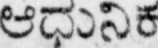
ಆಧುನಿಕ
